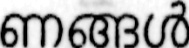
ണങ്ങള്‍
